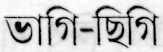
ভাগি-ছিগি
